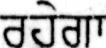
ਰਹੇਗਾ
